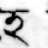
হৈ
